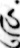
હું
